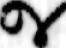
જ
